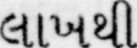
લાખથી
